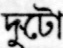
দুটো
